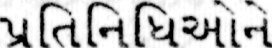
પ્રતિનિધિઓને
